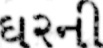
ઘરની
